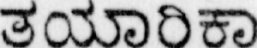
ತಯಾರಿಕಾ
